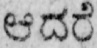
ಆದರೆ
